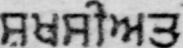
ਸ਼ਖਸੀਅਤ
